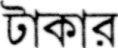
টাকার
